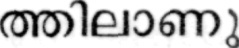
ത്തിലാണു
